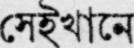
সেইখানে
